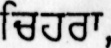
ਚਿਹਰਾ,
